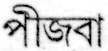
পীজবা
